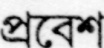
প্রবেশ
